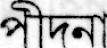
পীদনা
